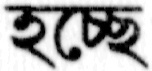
হচ্ছে
